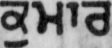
ਕੁਮਾਰ
